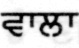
ਵਾਲਾ
